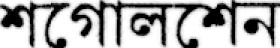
শহোলশেন
